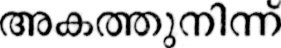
അകത്തുനിന്ന്
